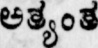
ಅತ್ಯಂತ
